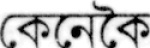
কেনেকৈ
